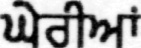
ਘੇਰੀਆਂ
